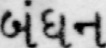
બંધન
